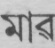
মাৱ
